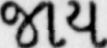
જાય
